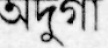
অদুগা
